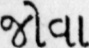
જોવા
